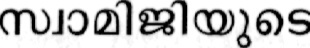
സ്വാമിജിയുടെ
